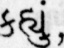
કહ્યું,
